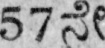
57ನೇ
